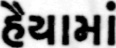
હૈયામાં
